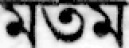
মতম
